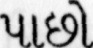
પાછો
